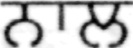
ਨਾਲ
